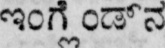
ಇಂಗ್ಲೆಂಡ್‌ನ
